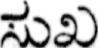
ಸುಖ
